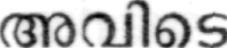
അവിടെ
